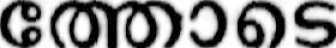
ത്തോടെ
